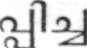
പ്പിച്ച
